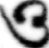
ও
